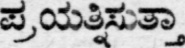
ಪ್ರಯತ್ನಿಸುತ್ತಾ
